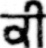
ਕੀ
